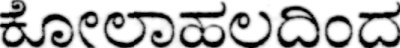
ಕೋಲಾಹಲದಿಂದ
